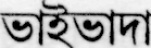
ভাইভাদা
